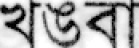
খঙবা
